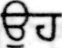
ਉਹ
